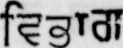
ਵਿਭਾਗ
